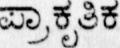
ಪ್ರಾಕೃತಿಕ
